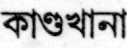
কাণ্ডখানা
